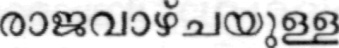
രാജവാഴ്ചയുള്ള
